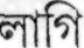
লাগি
